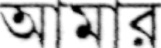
আমার
